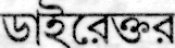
ডাইরেক্তর
